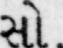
સો.
